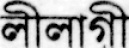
লীলাগী
